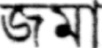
জমা
